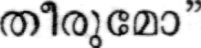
തീരുമോ”
